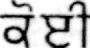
ਕੋਈ
